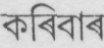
কৰিবাৰ
